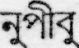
নুপীবু
